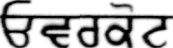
ਓਵਰਕੋਟ
